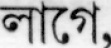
লাগে,
